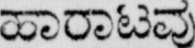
ಹಾರಾಟವು
